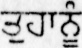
ਤੁਹਾਨੂੰ
